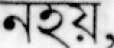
নহয়,
